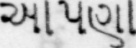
આપણા
